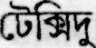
টেক্সিদু
